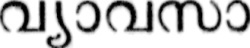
വ്യാവസാ
